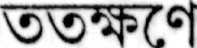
ততক্ষণে
